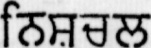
ਨਿਸ਼ਚਲ
